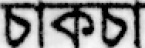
চাকচা
